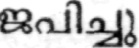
ജപിച്ചു
